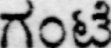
ಗ೦ಟೆ
